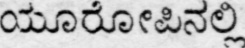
ಯೂರೋಪಿನಲ್ಲಿ
